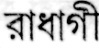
রাধাগী
